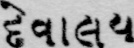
દેવાલય
